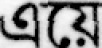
এয়ে
